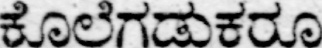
ಕೊಲೆಗಡುಕರೂ
